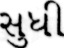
સુધી
